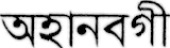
অহানবগী
